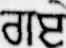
ਗਏ
